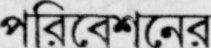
পরিবেশনের
